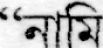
"নামি
